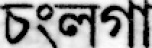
চংলগা
